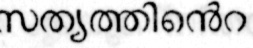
സത്യത്തിന്റെ
